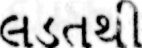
લડતથી
